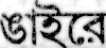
ঙাইরে
